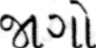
જાગો
